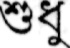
শুধু
